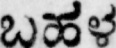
ಬಹಳ
